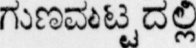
ಗುಣಮಟ್ಟದಲ್ಲಿ
